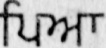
ਪਿਆ
